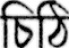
চিঠি
